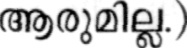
ആരുമില്ല.)
